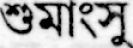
শুমাংসু
